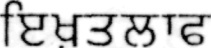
ਇਖ਼ਤਲਾਫ
